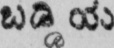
ಬಡ್ಡಿಯ
